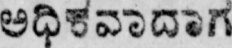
ಅಧಿಕವಾದಾಗ
